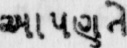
આપણને
